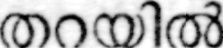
തറയില്‍
